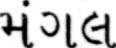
મંગલ
